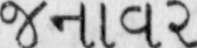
જનાવર
